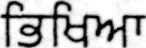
ਭਿਖਿਆ
